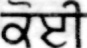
ਕੋਈ
